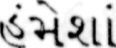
હંમેશાં
